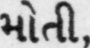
મોતી,
